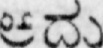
ಅದು
